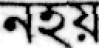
নহয়
